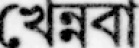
খেন্নবা
